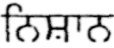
ਨਿਸ਼ਾਨ
